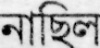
নাছিল
